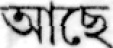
আছে
